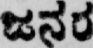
ಜನರ
